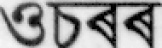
ওচৰৰ
